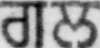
ਗਲ
